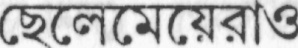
ছেলেমেয়েরাও
